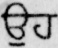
ਉਹ
